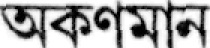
অকণমান
